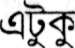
এটুকু
